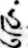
હું
